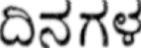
ದಿನಗಳ
